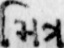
મિત્ર
